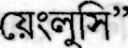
য়েংলুসি”
